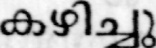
കഴിച്ചു
